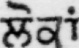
ਲੋਕਾਂ
